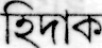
হিদাক
